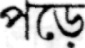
পড়ে
